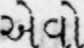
એવો
